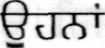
ਉਹਨਾਂ
